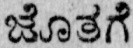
ಜೊತೆಗೆ
